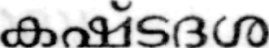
കഷ്ടദശ
